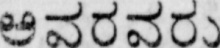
ಅವರವರು
